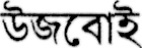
উজবোই
